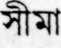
সীমা
